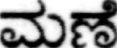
ಮಣೆ
